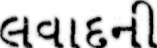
લવાદની
